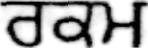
ਰਕਮ
